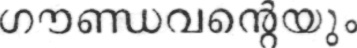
ഗൌണ്ഡവന്റെയും
